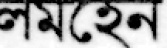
লমহেন
